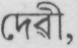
দেৱী,
